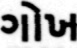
ગોખ
